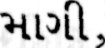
માગી,
